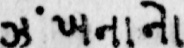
ઝંખનાનો
